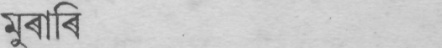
মুৰাৰি
